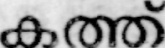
കത്ത്
